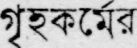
গৃহকর্মের
